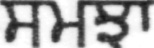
ਸਮਝਾ
